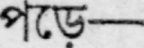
পড়ে—
